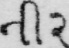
નીર
